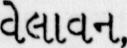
વેલાવન,
